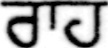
ਰਾਹ
